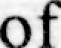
of
